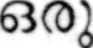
ഒരു
